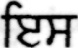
ਇਸ
